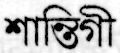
শান্তিগী
